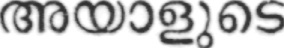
അയാളുടെ
